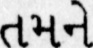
તમને
